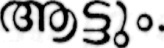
ആട്ടും.
